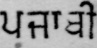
ਪਜਾਬੀ
